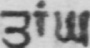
ਤਾਂਘ
